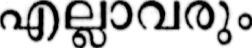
എല്ലാവരും
